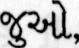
જુઓ,
